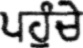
ਪਹੁੰਚੇ
